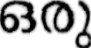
ഒരു
